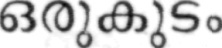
ഒരുകുടം
